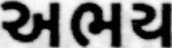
અભય
